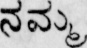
ನಮ್ಮ
